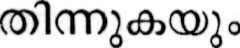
തിന്നുകയും
